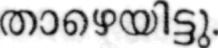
താഴെയിട്ടു.
